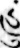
હું
